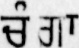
ਚੰਗਾ
